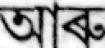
আৰু
